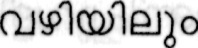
വഴിയിലും
